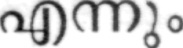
എന്നും
